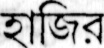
হাজির
